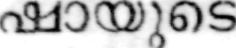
ഷായുടെ
